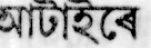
আটাইৰে
